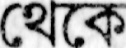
থেকে
